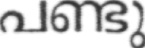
പണ്ടു
